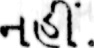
નહીં.
